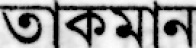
তাকমান
